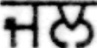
ਜਲ
